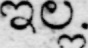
ಇಲ್ಲ.
